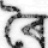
ৰৈ
